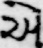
એ
